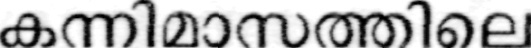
കന്നിമാസത്തിലെ
